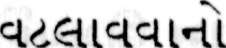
વટલાવવાનો
